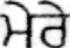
ਮੇਰੇ
